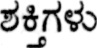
ಶಕ್ತಿಗಳು
